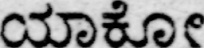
ಯಾಕೋ
